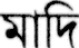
মাদি
